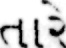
તારે
